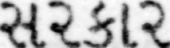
સરકાર
